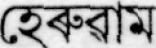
হেৰুৱাম
